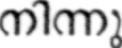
നിന്നു
